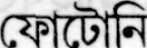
ফোটোনি
